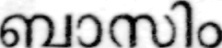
ബാസിം
